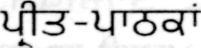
ਪ੍ਰੀਤ-ਪਾਠਕਾਂ
